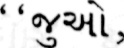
"જુઓ,
